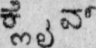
ಕ್ಲೈವ್
